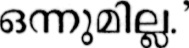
ഒന്നുമില്ല.'
